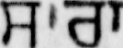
ਸਾਰਾ
